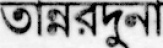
তান্নরদুনা
